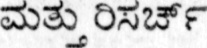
ಮತ್ತುರಿಸರ್ಚ್
